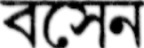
বসেন
